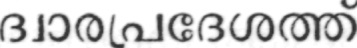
ദ്വാരപ്രദേശത്ത്
